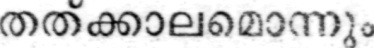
തത്ക്കാലമൊന്നും
